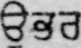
ਉਭਰ
